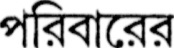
পরিবারের
